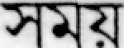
সময়
